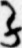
કે
